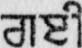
ਗਈ
